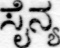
ಸೈನ್ಯ
